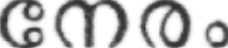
നേരം
